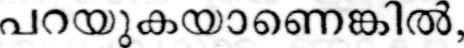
പറയുകയാണെങ്കില്‍,
